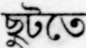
ছুটতে
